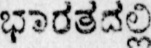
ಭಾರತದಲ್ಲಿ
